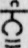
ਨੂੰ
